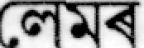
লেমৰ
